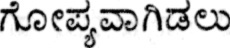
ಗೋಪ್ಯವಾಗಿಡಲು
